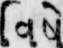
વિષે
